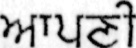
ਆਪਣੀ
